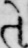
તે
